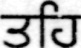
ਤਹਿ
